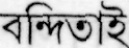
বন্দিতাই
